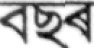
বছৰ
